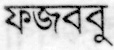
ফজববু
